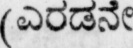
(ಎರಡನೇ
